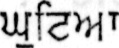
ਘੁਟਿਆ
